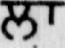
ਲਾ
